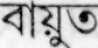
বায়ুত
